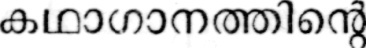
കഥാഗാനത്തിന്റെ
